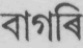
বাগৰি
